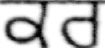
ਕਰ
